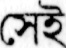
সেই
